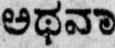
ಅಥವಾ
